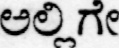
ಅಲ್ಲಿಗೇ
